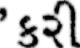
કરી
